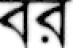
বর
